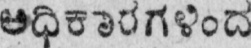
ಅಧಿಕಾರಗಳಿಂದ
